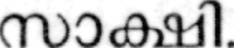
സാക്ഷി.
